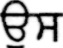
ਉਸ
